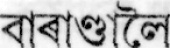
বাৰাণ্ডালৈ
